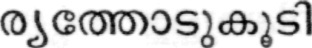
ര്യത്തോടുകൂടി
